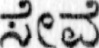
ಸೇವೆ
